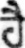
ਹੈ
